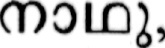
നാഥു,
